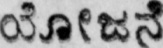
ಯೋಜನೆ
